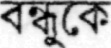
বন্ধুকে
